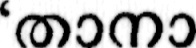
‘താനാ
